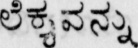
ಲೆಕ್ಕವನ್ನು
